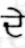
ਦੇ
